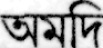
অমদি
